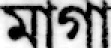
মাগা
